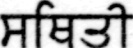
ਸਥਿਤੀ
